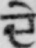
ਦੇ
